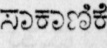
ಸಾಕಾಣಿಕೆ
